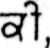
ਕੀ,
